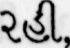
રહી,
